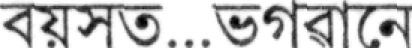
বয়সত...ভগৱানে
